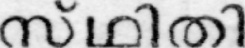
സ്ഥിതി
